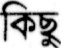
কিছু
